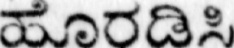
ಹೊರಡಿಸಿ
